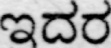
ಇದರ
